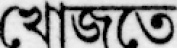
খোজতে
